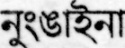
নুংঙাইনা
